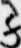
કે
